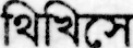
থিখিসে
